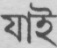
যাই
